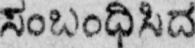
ಸಂಬಂಧಿಸಿದ
